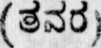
(ತವರ)
